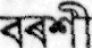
বৰশী
